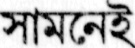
সামনেই
